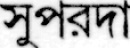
সুপরদা
